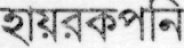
হায়রকপনি
